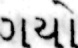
ગયો
